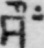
ਸੌਂ
